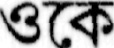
ওকে
